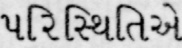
પરિસ્થિતિએ
